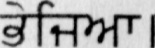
ਭੇਜਿਆ।
